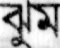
ঝুম
